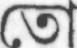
তো
